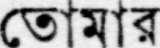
তোমার
